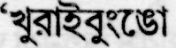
“খুরাইবুংঙো
